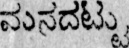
ಮನದಟ್ಟು
